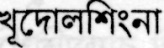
খূদোলশিংনা
